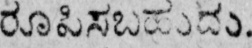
ರೂಪಿಸಬಹುದು.
